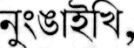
নুংঙাইখি,
